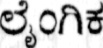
ಲೈಂಗಿಕ
